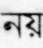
নয়
